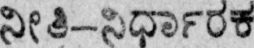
ನೀತಿ-ನಿರ್ಧಾರಕ
